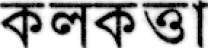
কলকত্তা
